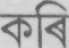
কৰি
